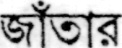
জাঁতার
